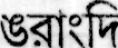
ঙরাংদি
